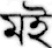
মই
